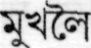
মুখলৈ
